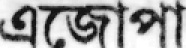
এজোপা
